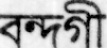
বন্দগী
